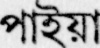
পাইয়া
